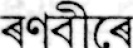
ৰণবীৰে
